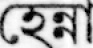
হেন্না
